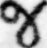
જ
